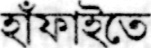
হাঁফাইতে
